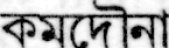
কমদৌনা
